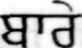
ਬਾਰੇ
